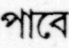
পাবে
